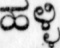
ಹಳ್ಳಿ
